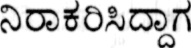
ನಿರಾಕರಿಸಿದ್ದಾಗ
